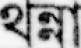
থন্না
